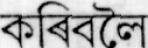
কৰিবলৈ
